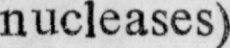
nucleases)
